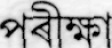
পৰীক্ষা
